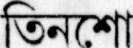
তিনশো
